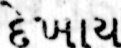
દેખાય
